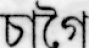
চাগৈ
